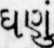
ઘણું
